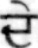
ਦੇ
